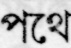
পথে
